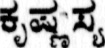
ಕೃಷ್ಣಸ್ಯ
